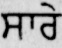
ਸਾਰੇ
